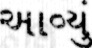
આવ્યું
